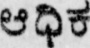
ಆಧಿಕ
